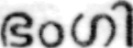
ഭംഗി
